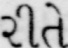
રીતે
